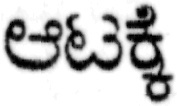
ಆಟಕ್ಕೆ
